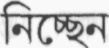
নিচ্ছেন
